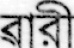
ৱারী
